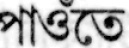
পাওঁতে
